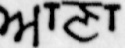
ਆਣਾ
